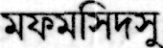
মফমসিদসু
